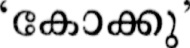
‘കോക്കു'
